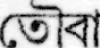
তৌবা
